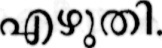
എഴുതി.
